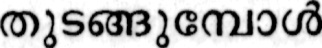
തുടങ്ങുമ്പോള്‍
